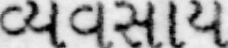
વ્યવસાય
